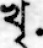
খৃ.
